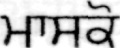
ਮਾਸਕੋ
